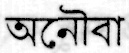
অনৌবা
